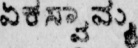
ಏಕಸ್ವಾಮ್ಯ
